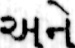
અને
